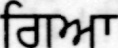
ਗਿਆ
